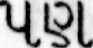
પણ
